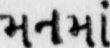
મનમાં
